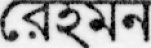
রেহমান
